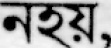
নহয়,
